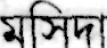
মসিদা
